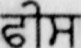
ਫੀਸ
